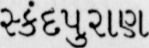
સ્કંદપુરાણ
